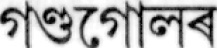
গণ্ডগোলৰ
